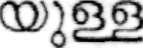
യുള്ള
